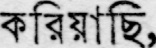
করিয়াছি,
